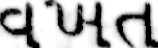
વખત
